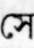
সে
